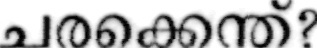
ചരക്കെന്ത്?
